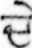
ਦੇ
